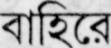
বাহিরে
